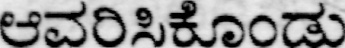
ಆವರಿಸಿಕೊಂಡು
